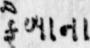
ફૈબાના
